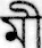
মী
